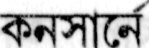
কনসার্নে
